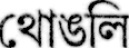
থোঙলি
